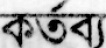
কর্তব্য
